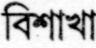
বিশাখা
